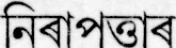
নিৰাপত্তাৰ
